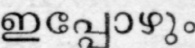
ഇപ്പോഴും
